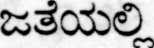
ಜತೆಯಲ್ಲಿ
